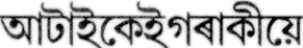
আটাইকেইগৰাকীয়ে
